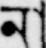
না
